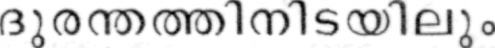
ദുരന്തത്തിനിടയിലും
